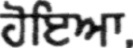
ਹੋਇਆ,
